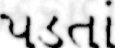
પડતાં
